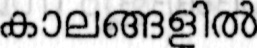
കാലങ്ങളില്‍
